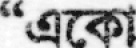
"একো
